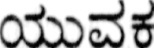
ಯುವಕ
